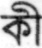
কী
